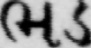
ભડ
